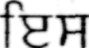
ਇਸ
